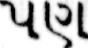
પણ
